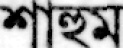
শাহুম
